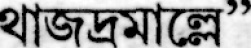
থাজদ্রমাল্লে”
